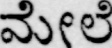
ಮೇಲೆ
